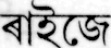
ৰাইজে
